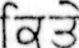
ਕਿਤੇ
